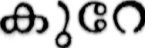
കുറേ
